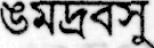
ঙমদ্রবসু
